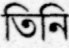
তিনি
